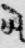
બે
